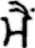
ਮੈਂ
